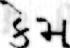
કેમ
